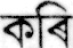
কৰি
